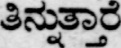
ತಿನ್ನುತ್ತಾರೆ
